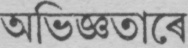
অভিজ্ঞতাৰে
